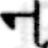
ન
